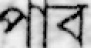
পাব
